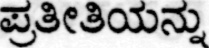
ಪ್ರತೀತಿಯನ್ನು
